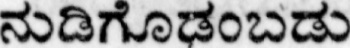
ನುಡಿಗೊಢಂಬಡು
